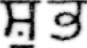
ਸ਼ੁਭ
